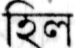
হিল
